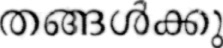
തങ്ങള്‍ക്കു
